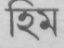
হিম
